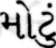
મોટું
